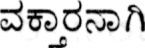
ವಕ್ತಾರನಾಗಿ
